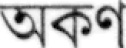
অকণ
